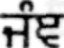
ਜੰਞ
